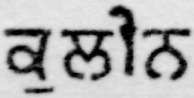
ਕੁਲੀਨ
